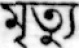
মৃত্যু
